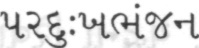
પરદુઃખભંજન
